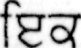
ਇਕ
